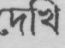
দেখি
